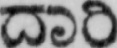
ದಾರಿ
